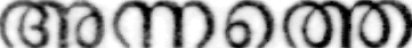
അന്നത്തെ
